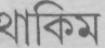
থাকিম
